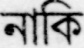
নাকি
